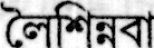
লৈশিন্নবা
